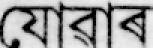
যোৱাৰ
